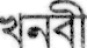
খনবী
